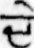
ਦੇ
